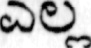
ಎಲ್ಲ
